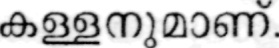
കള്ളനുമാണ്.
